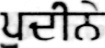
ਪੁਦੀਨੇ
